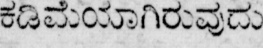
ಕಡಿಮೆಯಾಗಿರುವುದು
